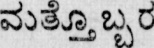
ಮತ್ತೊಬ್ಬರ
